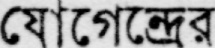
যোগেন্দ্রের
